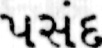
પસંદ
